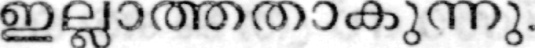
ഇല്ലാത്തതാകുന്നു.
